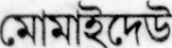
মোমাইদেউ
